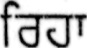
ਰਿਹਾ
